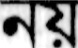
নয়
